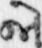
જો
